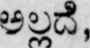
ಅಲ್ಲದೆ,
